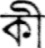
কী
